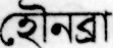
হৌনব্রা
